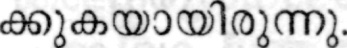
ക്കുകയായിരുന്നു.
